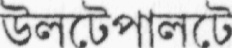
উলটেপালটে
